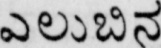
ಎಲುಬಿನ
